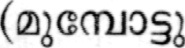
(മുമ്പോട്ടു
